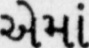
એમાં
